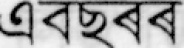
এবছৰৰ
